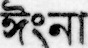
ঈংনা
